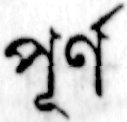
পূর্ণ
